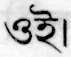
ওই।
